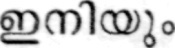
ഇനിയും
